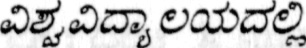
ವಿಶ್ವವಿದ್ಯಾಲಯದಲ್ಲಿ
